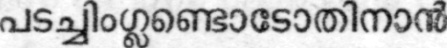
പടച്ചിംഗ്ലണ്ടൊടോതിനാന്‍
